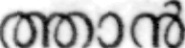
ത്താന്‍
